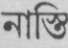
নাস্তি
